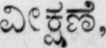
ವೀಕ್ಷಣೆ,
